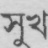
সুখ
